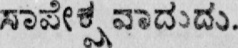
ಸಾಪೇಕ್ಷವಾದುದು.
